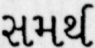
સમર્થ
